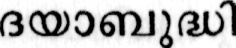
ദയാബുദ്ധി
